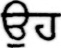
ਉਹ
